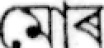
মোৰ
